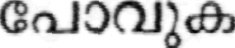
പോവുക
